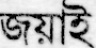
জয়াই
